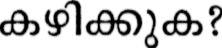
കഴിക്കുക?
